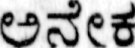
ಅನೇಕ
